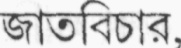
জাতবিচার,
